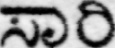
ಸಾರಿ
